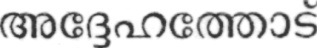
അദ്ദേഹത്തോട്
